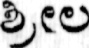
ಶ್ರೀಲ
